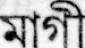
মাগী
